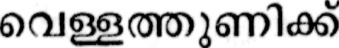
വെള്ളത്തുണിക്ക്
